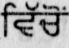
ਵਿੱਚੋਂ
